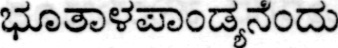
ಭೂತಾಳಪಾಂಡ್ಯನೆಂದು
